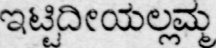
ಇಟ್ಟಿದೀಯಲ್ಲಮ್ಮ
